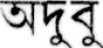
অদুবু
